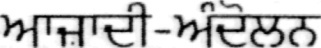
ਆਜ਼ਾਦੀ-ਅੰਦੋਲਨ
